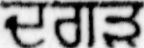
ਦਗੜ
